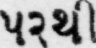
પરથી
